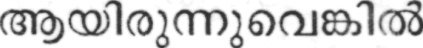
ആയിരുന്നുവെങ്കില്‍
